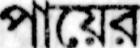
পায়ের
